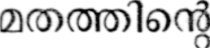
മതത്തിന്റെ
